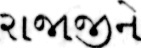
રાજાજીને
